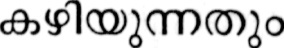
കഴിയുന്നതും
